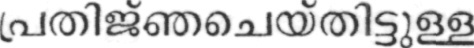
പ്രതിജ്ഞചെയ്തിട്ടുള്ള
